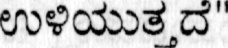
ಉಳಿಯುತ್ತದೆ”
